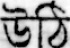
উঠি
